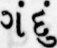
ગંદું
